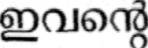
ഇവന്റെ
